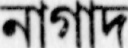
নাগাদ
